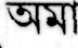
অমা
